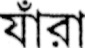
যাঁরা
